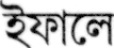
ইফালে
